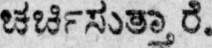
ಚರ್ಚಿಸುತ್ತಾರೆ.
